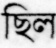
ছিল
